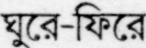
ঘুরে-ফিরে
